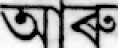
আৰু
